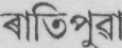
ৰাতিপুৱা
